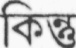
কিন্তু
